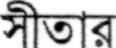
সীতার
